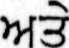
ਅਤੇ
